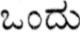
ಒಂದು
